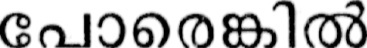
പോരെങ്കില്‍
